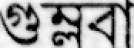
গুম্লবা
